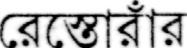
রেস্তোরাঁর
